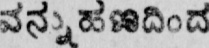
ವನ್ನುಹಣದಿಂದ
